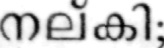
നല്കി;
